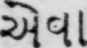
એવા
